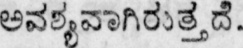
ಅವಶ್ಯವಾಗಿರುತ್ತದೆ.
